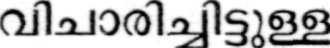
വിചാരിച്ചിട്ടുള്ള
